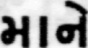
માને
